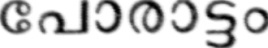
പോരാട്ടം
